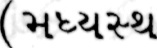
(મધ્યસ્થ
